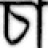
চা
